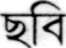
ছবি
